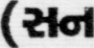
(સન
